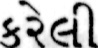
કરેલી
